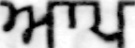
ਆਪ
